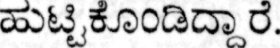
ಹುಟ್ಟಿಕೊಂಡಿದ್ದಾರೆ.
